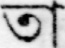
তা
